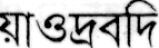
য়াওদ্রবদি
